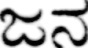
ಜನ
